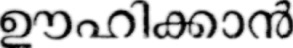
ഊഹിക്കാന്‍
